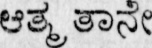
ಆತ್ಮತಾನೇ
